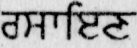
ਰਸਾਇਣ
